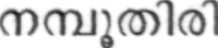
നമ്പൂതിരി
